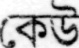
কেউ
